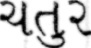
ચતુર
